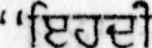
''ਇਹਦੀ
